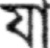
যা
